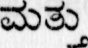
ಮತ್ತು
